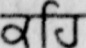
ਕਹਿ
